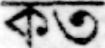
কত
